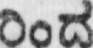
ರಿಂದ
